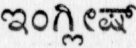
ಇಂಗ್ಲೀಷ್
